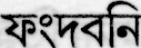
ফংদবনি
